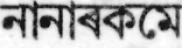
নানাৰকমে
